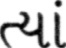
ત્યાં
